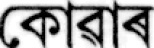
কোৱাৰ
